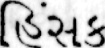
હિંસક
